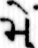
મેં
